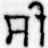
ਸੀ
